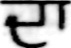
ਦਾ
